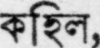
কহিল,
